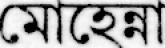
মোহেন্না
